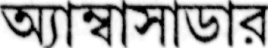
অ্যাম্বাসাডার
